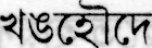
খঙহৌদে
